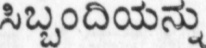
ಸಿಬ್ಬಂದಿಯನ್ನು
